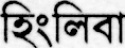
হিংলিবা
